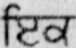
ਇਕ
